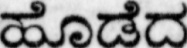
ಹೊಡೆದ
